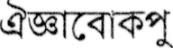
ঐজ্ঞাবোকপু
